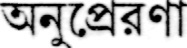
অনুপ্রেরণা
